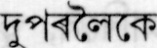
দুপৰলৈকে
